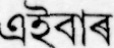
এইবাৰ
